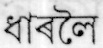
ধাৰলৈ
